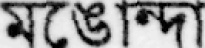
মঙোন্দা
